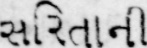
સરિતાની
